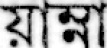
য়াম্না
